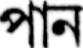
পান
